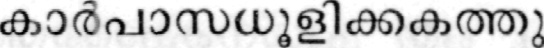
കാര്‍പാസധൂളിക്കകത്തു
